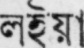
লইয়া
